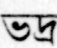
ভদ্র
